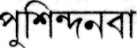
পুশিন্দনবা
